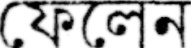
ফেলেন
